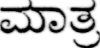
ಮಾತ್ರ
